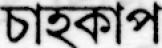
চাহকাপ
